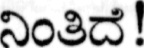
ನಿಂತಿದೆ!
